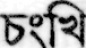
চংখি
